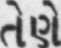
તેણે
